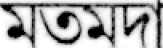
মতমদা
